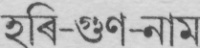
হৰি-গুণ-নাম
